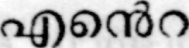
എന്റെ
